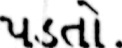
પડતો.
